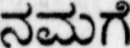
ನಮಗೆ
